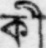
কী
